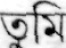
তুমি
